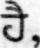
ਹੈ,
